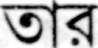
তার
